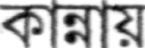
কান্নায়
